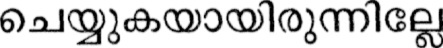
ചെയ്യുകയായിരുന്നില്ലേ
